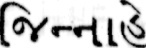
જિન્નાહે
